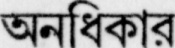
অনধিকার
